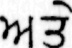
ਅਤੇ
